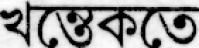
খন্তেকতে
